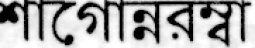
শাগোন্নরম্বা
